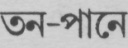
তন-পানে
